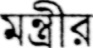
মন্ত্রীর
